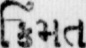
કિંમત
